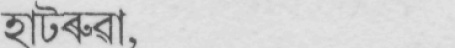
হাটৰৱা,
